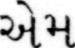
એમ
